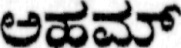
ಅಹಮ್
